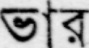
ভার
